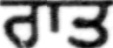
ਰਾਤ
